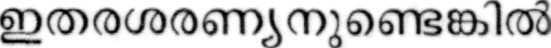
ഇതരശരണ്യനുണ്ടെങ്കില്‍
